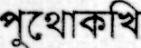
পুথোকখি
